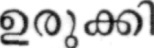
ഉരുക്കി
